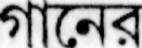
গানের
